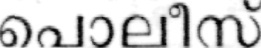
പൊലീസ്
